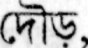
দৌড়,
